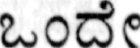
ಒಂದೇ
